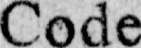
Code
